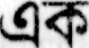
এক
